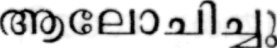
ആലോചിച്ചു
